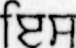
ਇਸ
